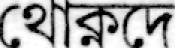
থোক্নদে
